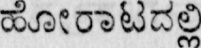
ಹೋರಾಟದಲ್ಲಿ
